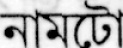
নামটো
